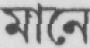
মানে
